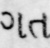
ગત
